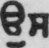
ਉਸ
